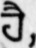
ਹੈ,
